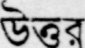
উত্তর
